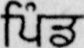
ਪਿੰਡ
